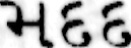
મદદ
